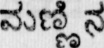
ಮಣ್ಣಿನ
